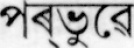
পৰ্‌ভুৱে
